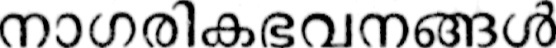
നാഗരികഭവനങ്ങള്‍
